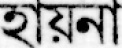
হায়না
